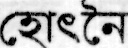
হোৎনৈ
